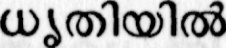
ധൃതിയില്‍
